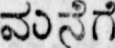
ಮನೆಗೆ
